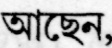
আছেন,
